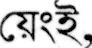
য়েংই,
